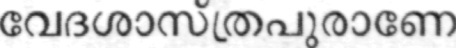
വേദശാസ്ത്രപുരാണേ
